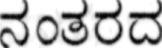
ನಂತರದ
